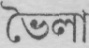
ভৈলা
